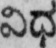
ವಿಧ
